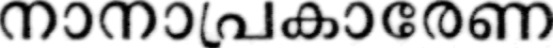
നാനാപ്രകാരേണ
